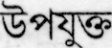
উপযুক্ত
